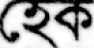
হেক
